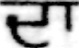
ਦਾ
